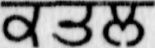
ਕਤਲ
